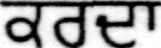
ਕਰਦਾ
